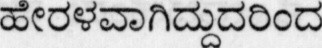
ಹೇರಳವಾಗಿದ್ದುದರಿಂದ
